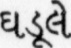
ઘડૂલે
